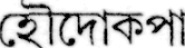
হৌদোক্পা
